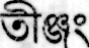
তীঞ্জং
